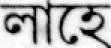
লাহে
